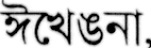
ঈখেঙনা,
